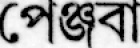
পেঞ্জবা
